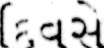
દિવસે
